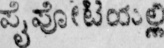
ಪೈಪೋಟಿಯಲ್ಲಿ
